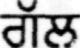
ਗੱਲ
